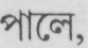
পালে,
